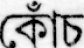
কোঁচ
